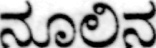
ನೂಲಿನ
